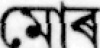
মোৰ
